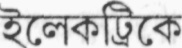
ইলেকট্রিকে
